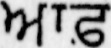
ਆਫ਼
